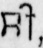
ਸੀ,
